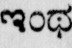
ಇಂಥ
